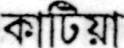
কাটিয়া
